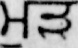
ਮੁੜ
